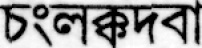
চংলক্কদবা
